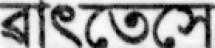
ৱাৎতেসে
